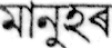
মানুহৰ
